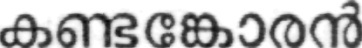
കണ്ടങ്കോരന്‍
